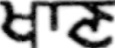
ਖਾਣ
